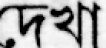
দেখা
